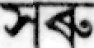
সৰু
